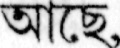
আছে,
